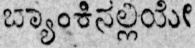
ಬ್ಯಾಂಕಿನಲ್ಲಿಯೇ
